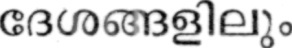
ദേശങ്ങളിലും
